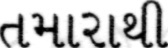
તમારાથી
